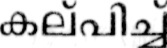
കല്പിച്ച്
